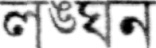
লঙ্ঘন
